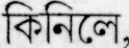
কিনিলে,
